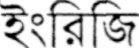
ইংরিজি
